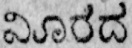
ಮೀರದ
